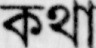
কথা
